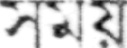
সময়
